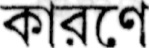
কারণে
